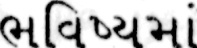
ભવિષ્યમાં
